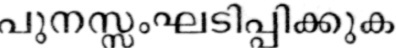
പുനസ്സംഘടിപ്പിക്കുക
